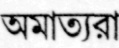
অমাত্যরা
